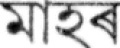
মাহৰ
